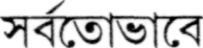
সর্বতোভাবে
